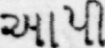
આપી
